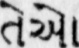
તેઓ
